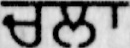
ਚਲਾ
